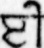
ਈ
